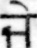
ਜੇ
